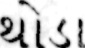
થોડા
